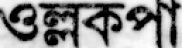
ওল্লকপা
